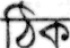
ঠিক
